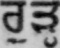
ਰੁੜ੍ਹ
